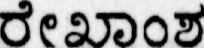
ರೇಖಾಂಶ
